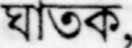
ঘাতক,
